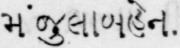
મંજુલાબહેન.
